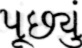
પૂછ્યું
